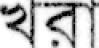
খরা
